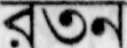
রতন
